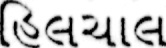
હિલચાલ
